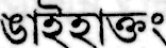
ঙাইহাক্তং
